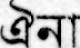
ঐনা
